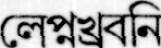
লেপ্নখ্রবনি
